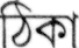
ঠিকা
